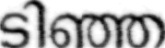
ടിഞ്ഞ
